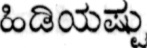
ಹಿಡಿಯಷ್ಟು
